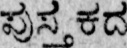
ಪುಸ್ತಕದ
